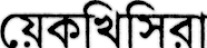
য়েকখিসিরা
